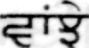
ਵਾਂਝੇ
